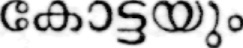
കോട്ടയും
